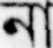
না
